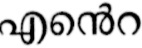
എന്റെ
